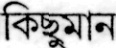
কিছুমান
